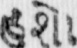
હશો
